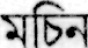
মচিন
